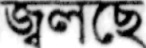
জ্বলছে
